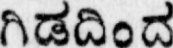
ಗಿಡದಿಂದ
